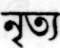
নৃত্য
